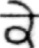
ਕੇ
